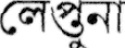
লেপ্তুনা
